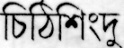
চিঠিশিংদু
